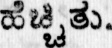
ಹೆಚ್ಚಿತು.
